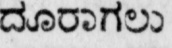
ದೂರಾಗಲು
